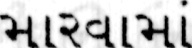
મારવામાં
